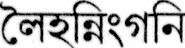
লৈহন্নিংগনি
